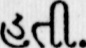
હતી.
